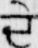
ਦੇ
